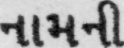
નામની
